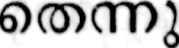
തെന്നു
